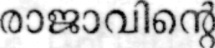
രാജാവിന്റെ
